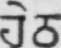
ਹੇਠ
